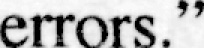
errors.”
